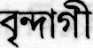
বৃন্দাগী
